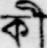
কী
